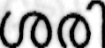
ശരി
